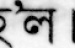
হ'ল
